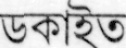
ডকাইত
